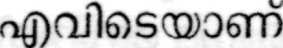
എവിടെയാണ്
